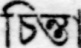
চিন্তা
